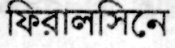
ফিরালসিনে
